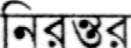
নিরন্তর
